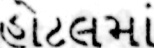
હોટલમાં
